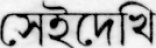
সেইদেখি
